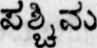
ಪಶ್ಚಿಮ
